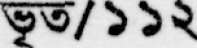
ভুত/১১২
